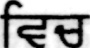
ਵਿਚ
